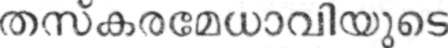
തസ്കരമേധാവിയുടെ
